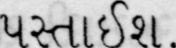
પસ્તાઈશ.
